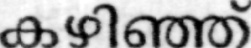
കഴിഞ്ഞ്
